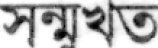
সন্মুখত
